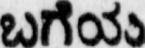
ಬಗೆಯ
